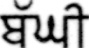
ਬੱਘੀ
